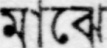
মাঝে
